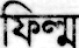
ফিল্ম
